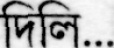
দিলি...
